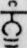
ਨੂੰ
